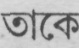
তাকে
